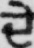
ਦੇ
